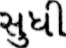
સુધી
